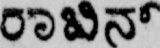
ರಾಬಿನ್
